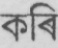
কৰি
